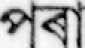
পৰা
